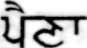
ਪੈਣਾ
